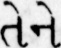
તેને
